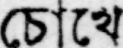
চোখে
